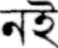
নই
